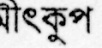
মীৎকুপ
